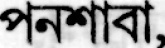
পনশাবা,
